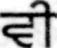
ਵੀ
